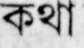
কথা
